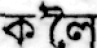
ক'লৈ
